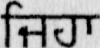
ਜਿਹਾ
